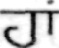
ਹਾਂ
